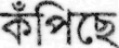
কঁপিছে
